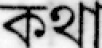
কথা
